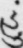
હું
